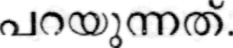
പറയുന്നത്.
